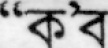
"ক'ব
